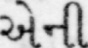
એની
